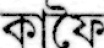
কাফৈ
